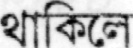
থাকিলে
